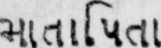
માતાપિતા
